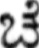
ಚೆ
